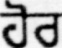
ਹੋਰ
